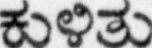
ಕುಳಿತು
